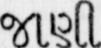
જાણી
